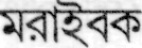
মরাইবক
